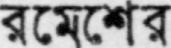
রমেশের
